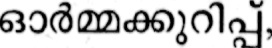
ഓര്‍മ്മക്കുറിപ്പ്,
